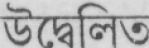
উদ্বেলিত
